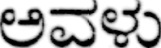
ಅವಳು
